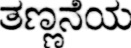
ತಣ್ಣನೆಯ
